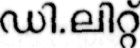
ഡി.ലിറ്റ്
